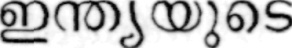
ഇന്ത്യയുടെ
